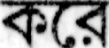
করে
